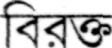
বিরক্ত
